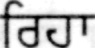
ਰਿਹਾ
